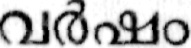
വര്‍ഷം
